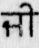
ਜੀ
